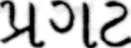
પ્રગટ
